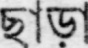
ছাড়া
